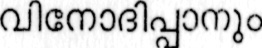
വിനോദിപ്പാനും
